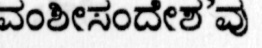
‘ವ೦ಶೀಸ೦ದೇಶ’ವು
